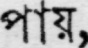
পায়,
